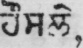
ਹੌਸਲੇ,
